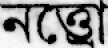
নত্ত্রো
